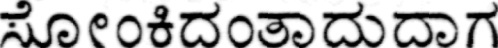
ಸೋಕಿದಂತಾದುದಾಗ
